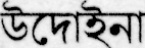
উদোইনা
